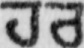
ਹਰ
